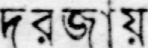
দরজায়
